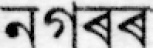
নগৰৰ
